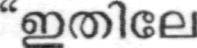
“ഇതിലേ
